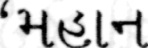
'મહાન
